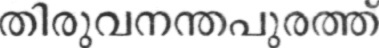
തിരുവനന്തപുരത്ത്
